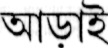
আড়াই
